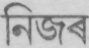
নিজৰ
